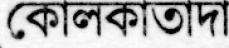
কোলকাতাদা
